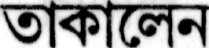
তাকালেন
